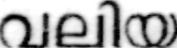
വലിയ
